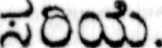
ಸರಿಯೆ.
